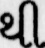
થી
